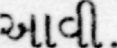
આવી.
